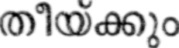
തീയ്ക്കും
